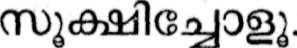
സൂക്ഷിച്ചോളൂ.
